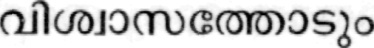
വിശ്വാസത്തോടും
